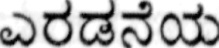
ಎರಡನೆಯ
